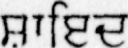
ਸ਼ਾਇਦ
